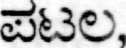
ಪಟಲ,
